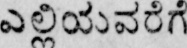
ಎಲ್ಲಿಯವರೆಗೆ
